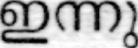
ഇന്നു
